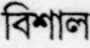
বিশাল
